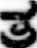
ತ
